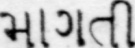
માગતી
